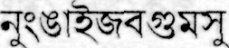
নুংঙাইজবগুমসু
